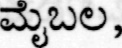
ಮೈಬಲ,
